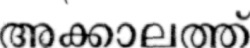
അക്കാലത്ത്
